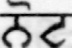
ਨੋਟ
